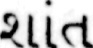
શાંત
